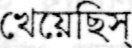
খেয়েছিস্
